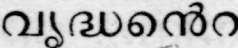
വൃദ്ധന്റെ
